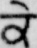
ਕੇ
